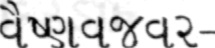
વૈષ્ણવજવર-
